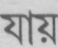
যায়
